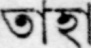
তাহা
